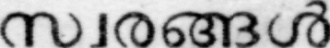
സ്വരങ്ങള്‍
